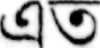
এত
